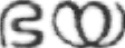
ഭയ
